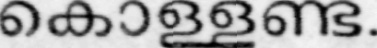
കൊള്ളണ്ട.
